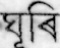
ঘূৰি
